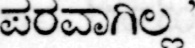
ಪರವಾಗಿಲ್ಲ'
